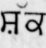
ਸ਼ੱਕ
